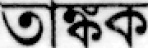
তাঙ্কক
